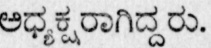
ಅಧ್ಯಕ್ಷರಾಗಿದ್ದರು.
